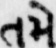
તમે
